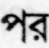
পর
